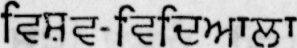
ਵਿਸ਼ਵ-ਵਿਦਿਆਲਾ
